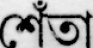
শেঁতা
